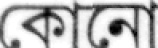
কোনো
